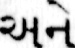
અને
